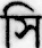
সি
